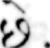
છે.
